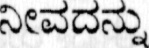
ನೀವದನ್ನು
